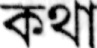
কথা
